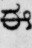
ಈ
